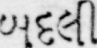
બદલી
